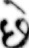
છે
